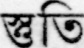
স্তুতি
